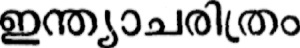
ഇന്ത്യാചരിത്രം
